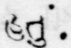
હતું.
